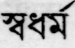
স্বধর্ম
